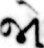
જો
